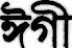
ঈগী
